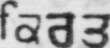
ਕਿਰਤ
